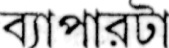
ব্যাপারটা
